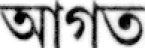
আগত
